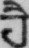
ਹੈ
